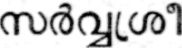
സര്‍വ്വശ്രീ
